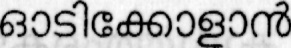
ഓടിക്കോളാന്‍
